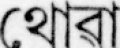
থোৱা
